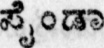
ಪೈಂಡಾ
